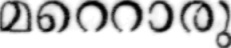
മറെറാരു
